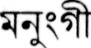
মনুংগী
